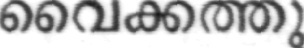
വൈക്കത്തു
